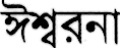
ঈশ্বরনা
